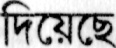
দিয়েছে
